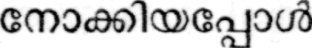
നോക്കിയപ്പോള്‍
